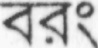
বরং
